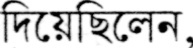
দিয়েছিলেন,
